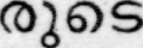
രുടെ
